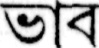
ভাব
